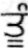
ਤੂੰ
